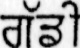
ਗੱਡੀ
